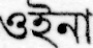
ওইনা
